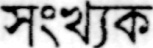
সংখ্যক
